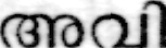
അവി
